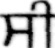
ਸੀ
